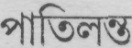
পাতিলন্ত
